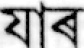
যাৰ
